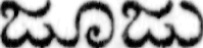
ಜೂಜು
